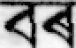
বৰ
